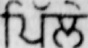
ਪਿੱਲੇ
